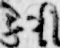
કેવી
